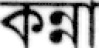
কন্না
